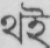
থই
